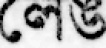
লেঙ
